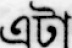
এটা
